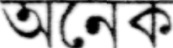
অনেক
